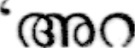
‘അറ
